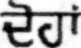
ਦੋਹਾਂ
